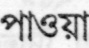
পাওয়া
